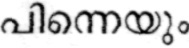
പിന്നെയും
